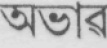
অভাৱ
